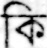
কি
